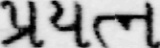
પ્રયત્ન
